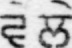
ਵੇਲੇ
